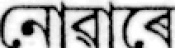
নোৱাৰে
